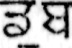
ਡੁਬ
